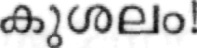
കുശലം!
